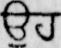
ਉਹ
